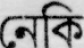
নেকি
